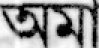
অমা
